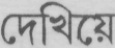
দেখিয়ে
